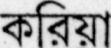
করিয়া
